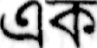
এক
